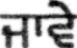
ਜਾਵੇ
